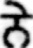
ਨੇ
